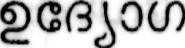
ഉദ്യോഗ
